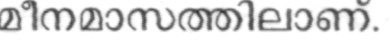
മീനമാസത്തിലാണ്.
